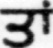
ਤਾਂ
